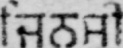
ਜਿਨਸੀ
